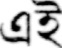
এই
